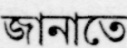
জানাতে
